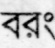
বরং
